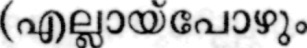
(എല്ലായ്പോഴും
